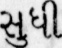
સુધી
